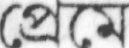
প্রেমে
